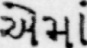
એમાં
